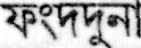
ফংদদুনা
